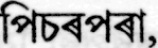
পিচৰপৰা,
